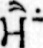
ਮੈਂ
